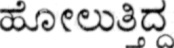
ಹೋಲುತ್ತಿದ್ದ
